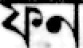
ফন
